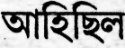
আহিছিল
